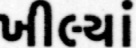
ખીલ્યાં
